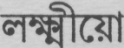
লক্ষ্মীয়ো
